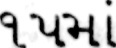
૧૫માં
